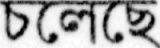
চলেছে
